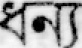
ধন্য
